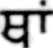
ਥਾਂ
